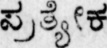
ಪ್ರತ್ಯೇಕ
